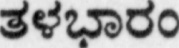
ತಳಭಾರಂ
